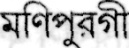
মণিপুরগী
